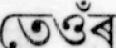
তেওঁৰ
